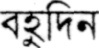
বহুদিন
